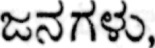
ಜನಗಳು,
